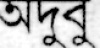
অদুবু
